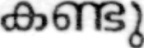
കണ്ടു
